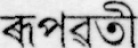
ৰূপৱতী
